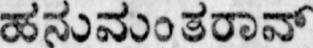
ಹನುಮಂತರಾವ್
